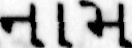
નામ
